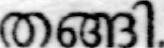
തങ്ങി.
